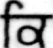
ਕਿ
